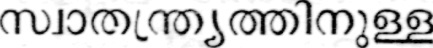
സ്വാതന്ത്ര്യത്തിനുള്ള
